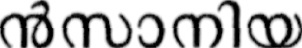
ന്‍സാനിയ
